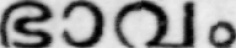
ഭാവം
